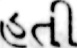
હતી
